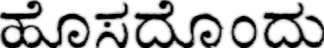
ಹೊಸದೊಂದು
